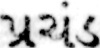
પ્રચંડ
